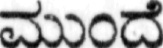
ಮುಂದೆ
